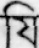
যি
